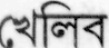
খেলিব
